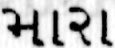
મારા
